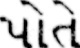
પોતે
